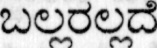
ಬಲ್ಲರಲ್ಲದೆ
